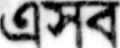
এসব
